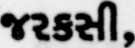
જરક્સી,
